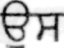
ਉਸ
